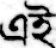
এই
